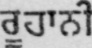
ਰੂਹਾਨੀ
